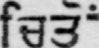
ਚਿਤੋਂ
